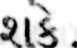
શકે.
